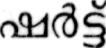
ഷര്‍ട്ട്
